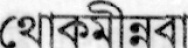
থোকমীন্নবা
